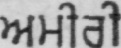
ਅਮੀਰੀ
